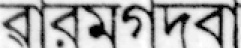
ৱারমগদবা
